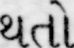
થતો
